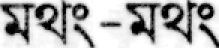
মথং-মথং
